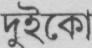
দুইকো
